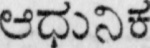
ಆಧುನಿಕ
